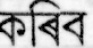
কৰিব
